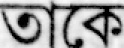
তাকে
